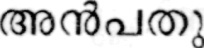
അന്‍പതു
